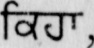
ਕਿਹਾ,
